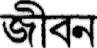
জীবন
